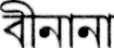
বীনানা
